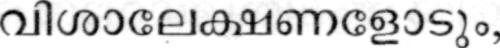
വിശാലേക്ഷണളോടും,
